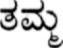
ತಮ್ಮ
